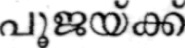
പൂജയ്ക്ക്
